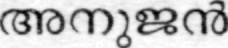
അനുജന്‍
